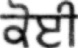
ਕੋਈ
